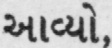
આવ્યો,
